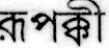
রূপক্কী
